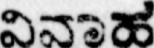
ವಿವಾಹ
